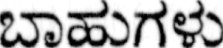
ಬಾಹುಗಳು
